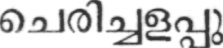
ചെരിച്ചളപ്പു
